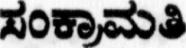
ಸಂಕ್ರಾಮತಿ
